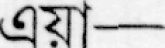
এয়া-
